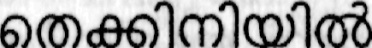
തെക്കിനിയില്‍
